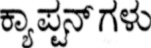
ಕ್ಯಾಪ್ಪನ್ಗಳು
